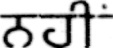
ਨਹੀਂ
